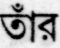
তাঁর
